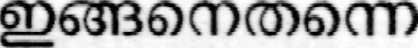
ഇങ്ങനെതന്നെ
